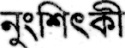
নুংশিৎকী
